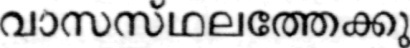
വാസസ്ഥലത്തേക്കു
